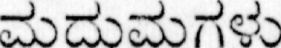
ಮದುಮಗಳು
